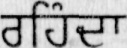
ਰਹਿੰਦਾ
